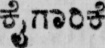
ಕೈಗಾರಿಕೆ
